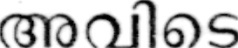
അവിടെ
